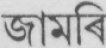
জামৰি
